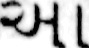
આ
